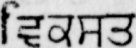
ਵਿਕਸਤ
